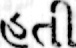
હતી
